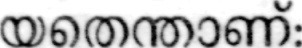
യതെന്താണ്:
